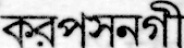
করপসনগী
